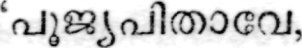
'പൂജ്യപിതാവേ,
